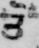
ਤੋਂ
